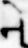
ને
